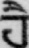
ਹੈ
